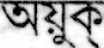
অয়ুক্
